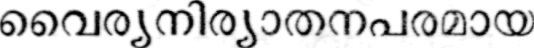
വൈര്യനിര്യാതനപരമായ
